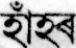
হাঁহৰ
